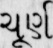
ચૂર્ણ
